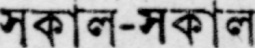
সকাল-সকাল
